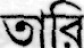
তারি
